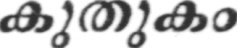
കുതുകം
